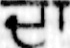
ਦਾ
